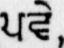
ਪਵੇ,
